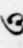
ও
